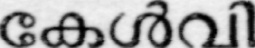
കേള്‍വി
